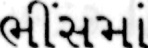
ભીંસમાં
